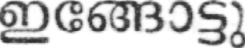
ഇങ്ങോട്ടു
